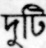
দুটি
